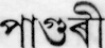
পাগুৰী
